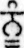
ਨੂੰ
